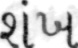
શંખ
